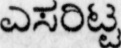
ಎಸರಿಟ್ಟ
